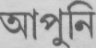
আপুনি
